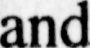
and
